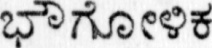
ಭೌಗೋಳಿಕ
